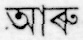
আৰু
